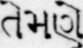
તેમણે
